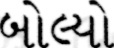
બોલ્યો
